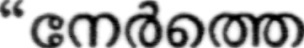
“നേര്‍ത്തെ
